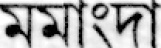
মমাংদা
